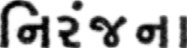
નિરંજના
